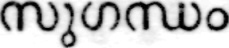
സുഗന്ധം
